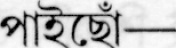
পাইছোঁ-
